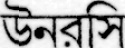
উনরসি
